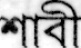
শাবী
